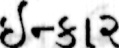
ઇન્કાર
